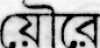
য়ৌরে
